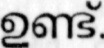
ഉണ്ട്.
